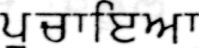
ਪੁਚਾਇਆ
